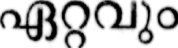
ഏറ്റവും
